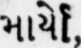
માર્યો,
